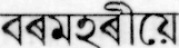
বৰমহৰীয়ে
